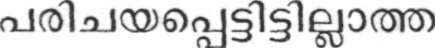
പരിചയപ്പെട്ടിട്ടില്ലാത്ത
